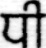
ਧੀ
